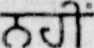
ਨਹੀਂ
